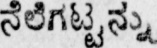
ನೆಲೆಗಟ್ಟನ್ನು
